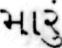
મારું
